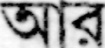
আর
